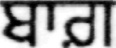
ਬਾਗ਼
